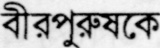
বীরপুরুষকে
